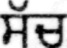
ਸੱਚ
